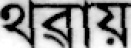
থৱায
